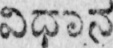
ವಿಧಾನ
